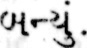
બન્યું.
